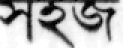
সহজ
